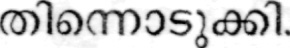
തിന്നൊടുക്കി.
